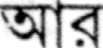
আর
